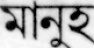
মানুহ
